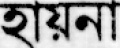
হায়না
